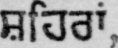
ਸ਼ਹਿਰਾਂ,
